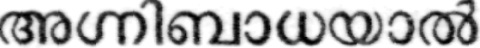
അഗ്നിബാധയാല്‍
